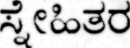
ಸ್ನೇಹಿತರ
